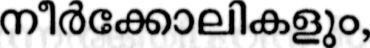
നീര്‍ക്കോലികളും,
